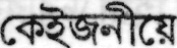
কেইজনীয়ে
